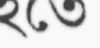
হতে
